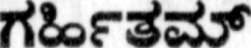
ಗರ್ಹಿತಮ್
